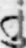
તું
